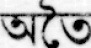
অতৈ
